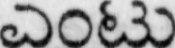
ಎಂಟು
